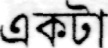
একটা
